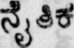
ನೈತಿಕ
